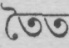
তৈত
